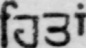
ਹਿਤਾਂ
